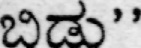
ಬಿಡು”
